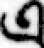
এ
